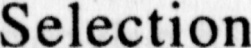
Selection
